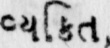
વ્યક્તિ,
